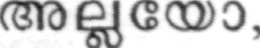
അല്ലയോ,
